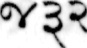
જરૂર
